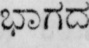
ಭಾಗದ
